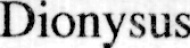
Dionysus
